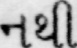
નથી
